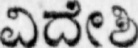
ವಿದೇಶಿ
